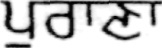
ਪੁਰਾਣਾ
